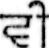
ਵੀ
